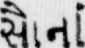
સૌનાં
